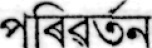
পৰিৱর্তন
